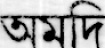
অমদি
